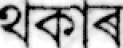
থকাৰ
